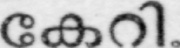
കേറി.
